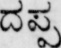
ದಪ್ಪ
